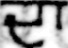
ਦਾ
